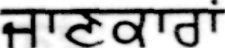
ਜਾਣਕਾਰਾਂ
